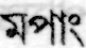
মপাং
